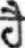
ਹੈ
